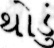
થોડું
